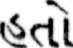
હતો
